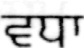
ਵਧਾ
